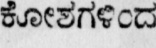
ಕೋಶಗಳಿಂದ
